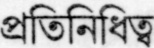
প্রতিনিধিত্ব
